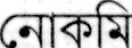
নোকমি
